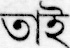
তাই
